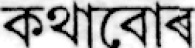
কথাবোৰ
